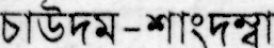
চাউদম-শাংদম্বা
